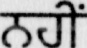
ਨਹੀਂ
